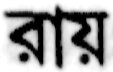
রায়
